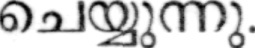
ചെയ്യുന്നു.
